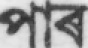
পাৰ
